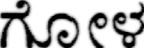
ಗೋಳ
